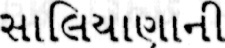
સાલિયાણાની
